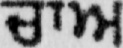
ਚਾਅ
